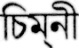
চিম্‌নী
